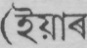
(ইয়াৰ
